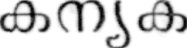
കന്യക
